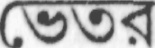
ভেতর
